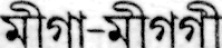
মীগা-মীগগী
